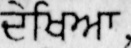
ਦੇਖਿਆ,
